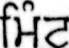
ਮਿੰਟ
